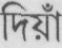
দিয়াঁ
